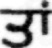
ਤਾਂ
